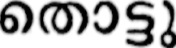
തൊട്ടു
